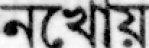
নখোয়
